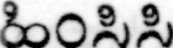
ಹಿಂಸಿಸಿ
